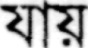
যায়
